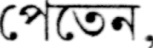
পেতেন,
